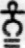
ਨੂੰ
